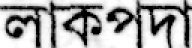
লাকপদা
